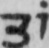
ਤਾਂ
